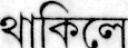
থাকিলে
